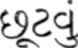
છૂટવું
